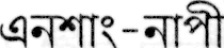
এনশাং-নাপী
